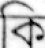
কি
